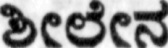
ಶೀಲೇನ
